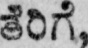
ತೆರಿಗೆ,
